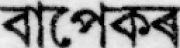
বাপেকৰ
